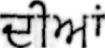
ਦੀਆਂ
